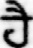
ਹੈ
